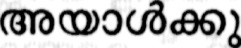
അയാള്‍ക്കു
